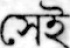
সেই
